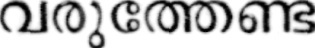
വരുത്തേണ്ട
